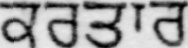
ਕਰਤਾਰ
